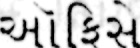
ઓફિસે
